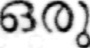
ഒരു
